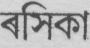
ৰসিকা
